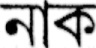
নাক
